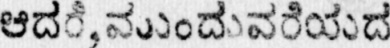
ಆದರೆಮುಂದುವರೆಯದ
